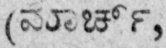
(ಮಾರ್ಚ್,
